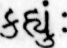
કહ્યું:
